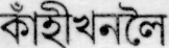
কাঁহীখনলৈ
